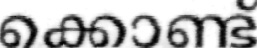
ക്കൊണ്ട്
